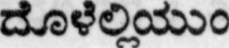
ದೊಳೆಲ್ಲಿಯುಂ
